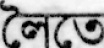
লৈতে
